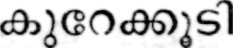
കുറേക്കൂടി
